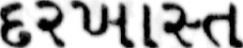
દરખાસ્ત
